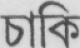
চাকি
